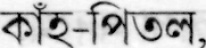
কাঁহ-পিতল,
